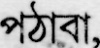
পঠাবা,
